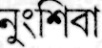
নুংশিবা
